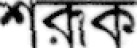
শরূক
